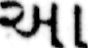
આ
